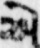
એ
